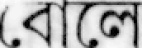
বোলে
